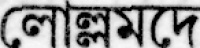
লোল্লমদে
